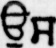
ਉਸ
